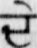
ਦੇ
